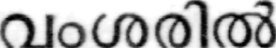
വംശരില്‍
